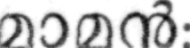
മാമന്‍:
